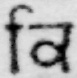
ਕਿ
